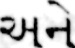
અને
